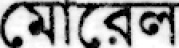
মোরেল
